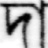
দা
